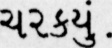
ચરકયું.
